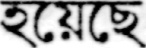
হয়েছে
